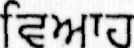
ਵਿਆਹ
